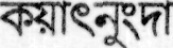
কয়াৎনুংদা
